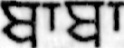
ਬਾਬਾ
